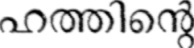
ഹത്തിന്റെ
